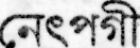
নেৎপগী
